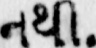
નથી.
